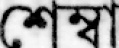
শেম্বা
